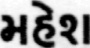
મહેશ
